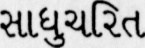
સાધુચરિત
